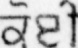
ਕੋਈ
